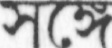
সঙ্গে
